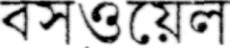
বসওয়েল
